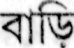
বাড়ি
